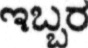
ಇಬ್ಬರ
